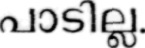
പാടില്ല.
